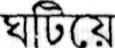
ঘটিয়ে
